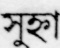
সুহ্না
